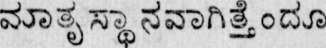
ಮಾತೃಸ್ಥಾನವಾಗಿತ್ತೆಂದೂ
